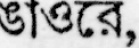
ঙাওরে,
